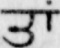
ਤਾਂ
